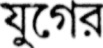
যুগের
